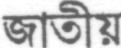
জাতীয়
